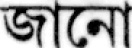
জানো
